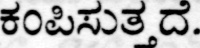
ಕಂಪಿಸುತ್ತದೆ.
